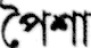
পৈশা
